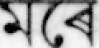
মৰে
